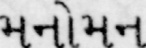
મનોમન
